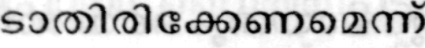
ടാതിരിക്കേണമെന്ന്
